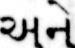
અને
